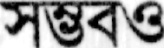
সম্ভবও
